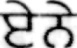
ਏਨੇ
